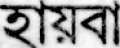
হায়বা
